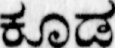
ಕೂಡ
